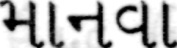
માનવા
